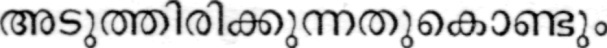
അടുത്തിരിക്കുന്നതുകൊണ്ടും
